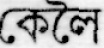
কেলৈ
